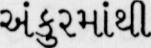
અંકુરમાંથી
